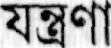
যন্ত্রণা
